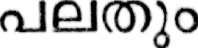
പലതും
